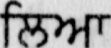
ਲਿਆ
